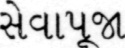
સેવાપૂજા
